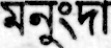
মনুংদা
